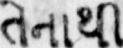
તેનાથી
